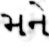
મને
